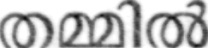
തമ്മില്‍
